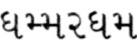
ધમ્મરધમ
